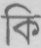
কি
